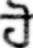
ਹੋ
